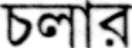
চলার
